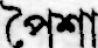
পৈশা
